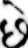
છે
